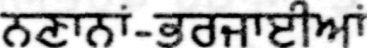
ਨਣਾਨਾਂ-ਭਰਜਾਈਆਂ
